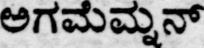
ಅಗಮೆಮ್ನನ್
